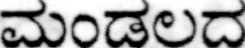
ಮಂಡಲದ
